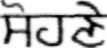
ਸੋਹਣੇ
